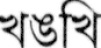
খঙখি
